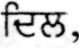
ਦਿਲ,
